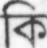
কি
